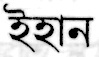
ইহান
